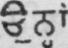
ਉਨ੍ਹਾਂ
